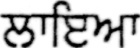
ਲਾਇਆ
